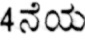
4ನೆಯ
